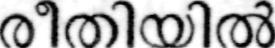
രീതിയില്‍
